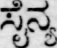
ಸೈನ್ಯ
